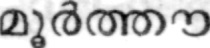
മൂര്‍ത്തൌ
